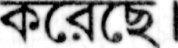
করেছে।
